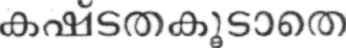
കഷ്ടതകൂടാതെ
